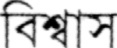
বিশ্বাস
